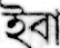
ইবা
